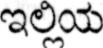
ಇಲ್ಲಿಯ
